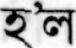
হ'ল
